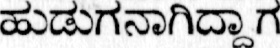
ಹುಡುಗನಾಗಿದ್ದಾಗ
